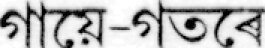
গায়ে-গতৰে
